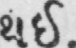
થઈ.
